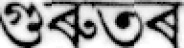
গুৰুতৰ
